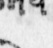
જાય
